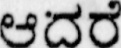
ಆದರೆ
